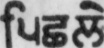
ਪਿਛਲੇ
